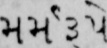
મર્મરૂપે
